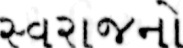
સ્વરાજનો
